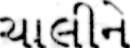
ચાલીને
